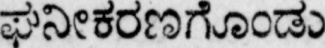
ಘನೀಕರಣಗೊಂಡು
